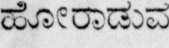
ಹೋರಾಡುವ
